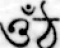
ওঁঠ
